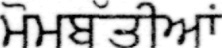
ਮੋਮਬੱਤੀਆਂ
